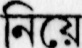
নিয়ে
